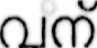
വന്
